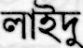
লাইদু
